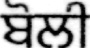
ਬੋਲੀ
